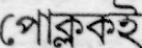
পোক্লকই
